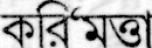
করি‘মত্তা
